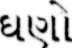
ઘણો
